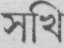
সখি
